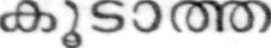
കൂടാത്ത
